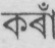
কৰাঁ
